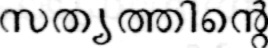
സത്യത്തിന്റെ
